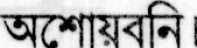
অশোয়বনি।
